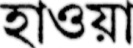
হাওয়া
